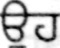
ਉਹ
